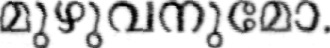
മുഴുവനുമോ,
